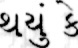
થયુંકે
